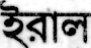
ইরাল
